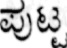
ಪುಟ್ಟ
